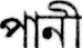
পানী
